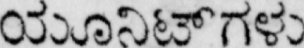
ಯೂನಿಟ್ಗಳು
